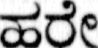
ಹರೇ
